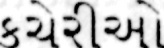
કચેરીઓ
